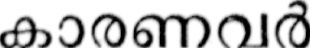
കാരണവര്‍
